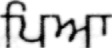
ਪਿਆ
